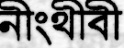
নীংথীবী
